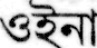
ওইনা
